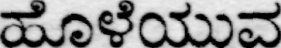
ಹೊಳೆಯುವ
